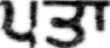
ਪਤਾ
